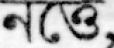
নত্তে,
